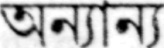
অন্যান্য
